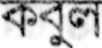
কবুল
